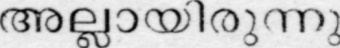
അല്ലായിരുനു
